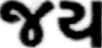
જય
